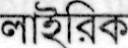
লাইরিক
